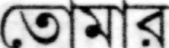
তোমার
